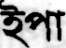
ইপা
